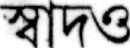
স্বাদও
